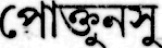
পোক্তুনসু
